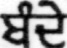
ਬੰਦੇ
